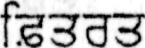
ਫ਼ਿਤਰਤ
